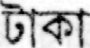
টাকা
